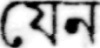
যেন
